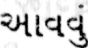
આવવું
